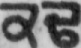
ਕਢ
